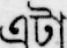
এটা
